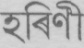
হৰিণী
